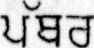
ਪੱਥਰ
